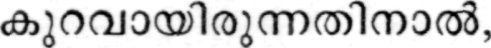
കുറവായിരുന്നതിനാല്‍,
